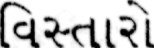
વિસ્તારો
